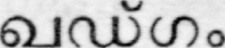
ഖഡ്ഗം
